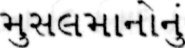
મુસલમાનોનું
